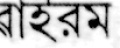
ৱাইরম
